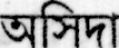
অসিদা
